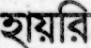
হায়রি
